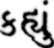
કહ્યું
